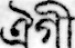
ঐগী
